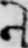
ને
